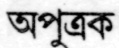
অপুত্রক
